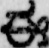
ಈ
